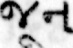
જૂન
